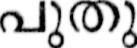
പുതു
